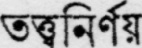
তত্ত্বনির্ণয়
